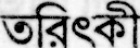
তরিৎকী
